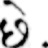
છે.
